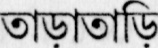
তাড়াতাড়ি
